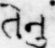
તેનું
